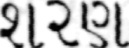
શરણ
